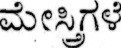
ಮೇಸ್ತ್ರಿಗಳೆ
